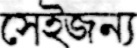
সেইজন্য
